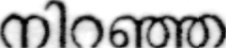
നിറഞ്ഞ
